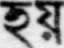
হয়
